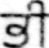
ਭੀ
